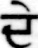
ਦੇ
